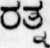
ರತ್ನ
